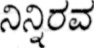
ನಿನ್ನಿರವ
